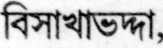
বিসাখাভদ্দা,
